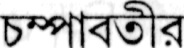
চম্পাবতীর
